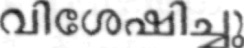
വിശേഷിച്ചു
